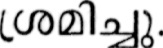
ശ്രമിച്ചു.
